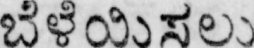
ಬೆಳೆಯಿಸಲು
